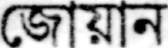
জোয়ান
